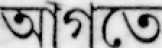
আগতে
